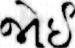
જોઈ
